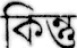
কিন্তু
